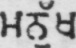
ਮਨੁੱਖ
